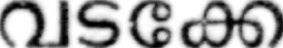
വടക്കേ
